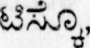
ಟಿಸ್ಕೊ,
